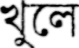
খুলে
